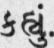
કહ્યું.
